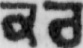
ਕਰ
